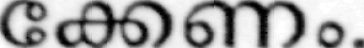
ക്കേണം.
